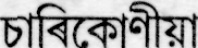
চাৰিকোণীয়া
